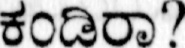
ಕಂಡಿರಾ?
